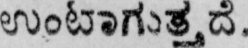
ಉಂಟಾಗುತ್ತದೆ.
